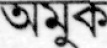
অমুক
